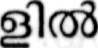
ളില്‍
